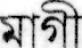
মাগী
